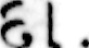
દા.
